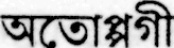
অতোপ্পগী
